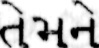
તેમને
